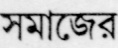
সমাজের
